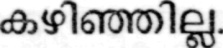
കഴിഞ്ഞില്ല.
